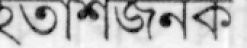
হতাশজনক
